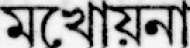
মখোয়না
